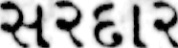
સરદાર
